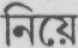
নিয়ে
